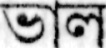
ভাল
